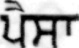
ਪੈਸਾ
